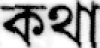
কথা
